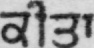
ਕੀਤਾ
